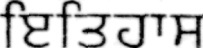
ਇਤਿਹਾਸ
